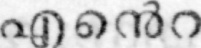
എന്റെ
